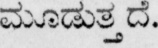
ಮೂಡುತ್ತದೆ.
